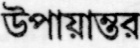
উপায়ান্তর
